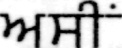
ਅਸੀਂ
